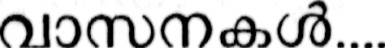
വാസനകള്‍....
